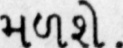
મળશે.
